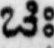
ಚಿಃ
